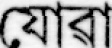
যোৱা
